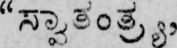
“ಸ್ವಾತಂತ್ರ್ಯ,
